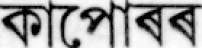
কাপোৰৰ
